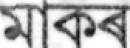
মাকৰ
